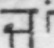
ਜਾਂ
